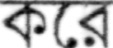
করে
